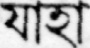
যাহা
